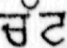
ਚੱਟ
